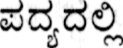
ಪದ್ಯದಲ್ಲಿ
